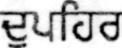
ਦੁਪਹਿਰ
